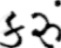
કરું
